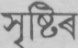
সৃষ্টিৰ
